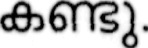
കണ്ടു.
